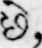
છે,
